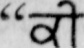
''ਕੀ
